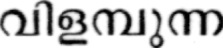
വിളമ്പുന്ന
